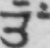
ਤੋਂ
